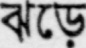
ঝড়ে
